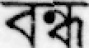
বন্ধ
